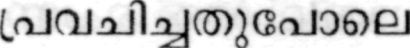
പ്രവചിച്ചതുപോലെ
